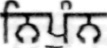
ਨਿਪੁੰਨ
